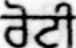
ਰੋਟੀ
